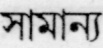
সামান্য
